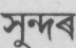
সুন্দৰ
